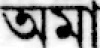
অমা
